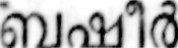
ബഷീര്‍
